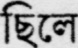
ছিলে
